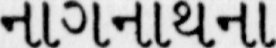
નાગનાથના
